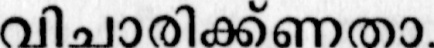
വിചാരിക്ക്ണതാ.
